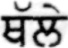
ਥੱਲੇ
